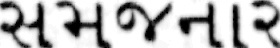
સમજનાર
